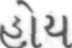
હોય
